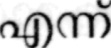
എന്ന്
